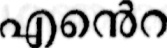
എന്റെ
